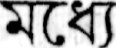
মধ্যে
